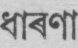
ধাৰণা
